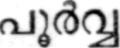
പൂര്‍വ്വ
